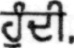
ਹੁੰਦੀ,
